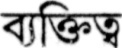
ব্যক্তিত্ব
